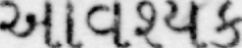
આવશ્યક
